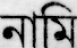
নামি
